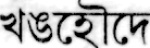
খঙহৌদে
